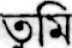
তুমি
